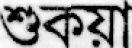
শুকয়া
